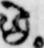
છે.
